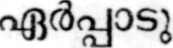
ഏര്‍പ്പാടു
